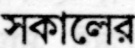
সকালের
